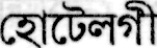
হোটেলগী
